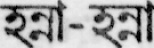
হন্না-হন্না
